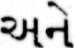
અને
